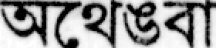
অথেঙবা
